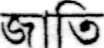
জাতি
